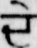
ਦੇ
